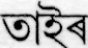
তাইৰ
